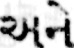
અને
